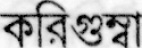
করিগুম্বা
